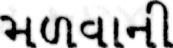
મળવાની
